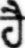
ਹੈ
